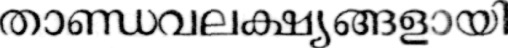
താണ്ഡവലക്ഷ്യങ്ങളായി
